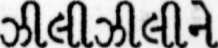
ઝીલીઝીલીને
